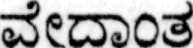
ವೇದಾಂತ
